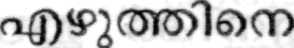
എഴുത്തിനെ
